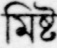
মিষ্ট
